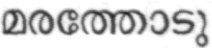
മരത്തോടു
